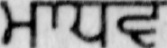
ਮਾਧਵ
